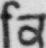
ਕਿ
